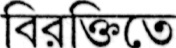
বিরক্তিতে
